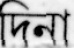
দিনা
